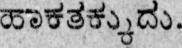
ಹಾಕತಕ್ಕುದು.
